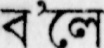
ব'লে
